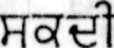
ਸਕਦੀ
